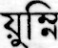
য়ুম্নি
